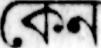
কেন
